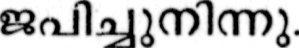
ജപിച്ചുനിന്നു.
